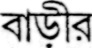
বাড়ীর
